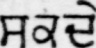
ਸਕਦੇ
